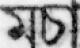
মচা
